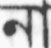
না
